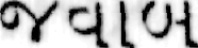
જવાબ
